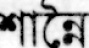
শান্নৈ
